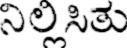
ನಿಲ್ಲಿಸಿತು
